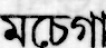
মচেগা
